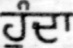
ਹੁੰਦਾ
